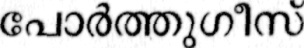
പോര്‍ത്തുഗീസ്
